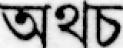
অথচ
